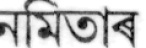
নমিতাৰ
